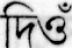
দিওঁ
